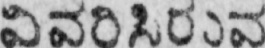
ವಿವರಿಸಿರುವ
